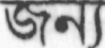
জন্য
